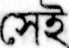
সেই
